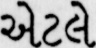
એટલે
